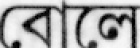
বোলে
